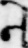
ને
